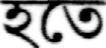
হতে
